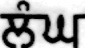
ਲੰਘ
